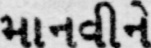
માનવીને
